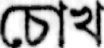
চোখ
